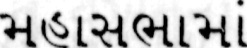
મહાસભામાં
